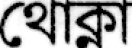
থোক্না
